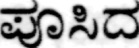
ಪೂಸಿದ
